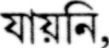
যায়নি,
